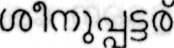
ശീനുപ്പട്ടര്
